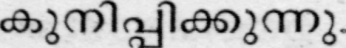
കുനിപ്പിക്കുന്നു.
